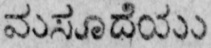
ಮಸೂದೆಯು
